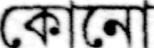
কোনো
